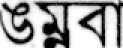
ঙম্নবা
